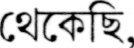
থেকেছি,
